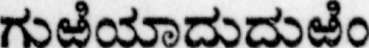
ಗುಱಯಾದುದುಱಂ
